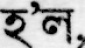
হ'ল,
